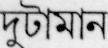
দুটামান
